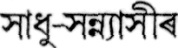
সাধু-সন্ন্যাসীৰ
